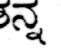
ತನ್ನ
